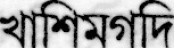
খাশিমগদি
